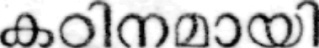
കഠിനമായി
